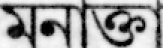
মনাক্তা
